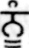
ਨੂੰ
